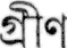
গ্রীণ
